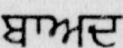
ਬਾਅਦ
